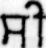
ਸੀ
